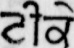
ਟੀਕੇ
